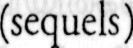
(sequels)
